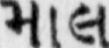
માલ
